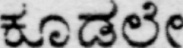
ಕೂಡಲೇ
